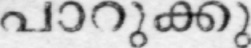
പാറുക്കു
